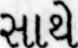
સાથે
